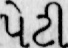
પેટી
